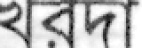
খরদা
